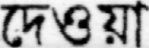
দেওয়া
